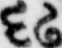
દઢ
